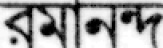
রমানন্দ
